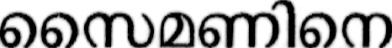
സൈമണിനെ
